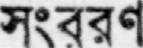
সংররণ
